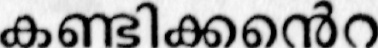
കണ്ടിക്കന്റെ
